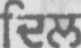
ਦਿਲ
